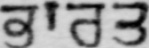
ਭਾਰਤ
